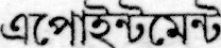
এপোইন্টমেন্ট
